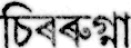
চিৰৰুগ্না
